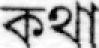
কথা
